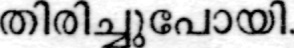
തിരിച്ചുപോയി.
